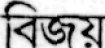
বিজয়
